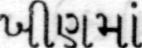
ખીણમાં
